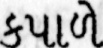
કપાળે
